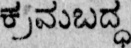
ಕ್ರಮಬದ್ಧ
